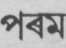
পৰম
